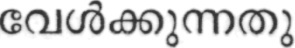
വേള്‍ക്കുന്നതു
